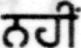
ਨਹੀਂ
